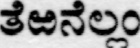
ತೆಱನೆಲ್ಲಂ
